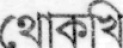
থোকখি
